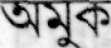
অমুক
